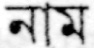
নাম
